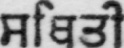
ਸਥਿਤੀ
